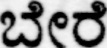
ಬೇರೆ
